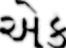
એક
